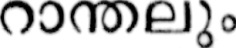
റാന്തലും
